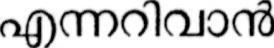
എന്നറിവാന്‍
